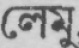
লেমু,
